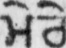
ਮੇਰੇ
